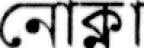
নোক্না
